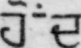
ਹੋਂਦ
